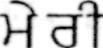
ਮੇਰੀ
